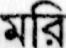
মরি
